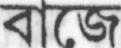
বাজে
